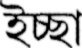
ইচ্ছা
